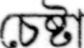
চেষ্টা
